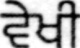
ਵੇਖੀ
